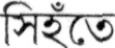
সিহঁতে
